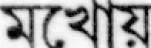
মখোয়
